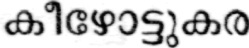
കീഴോട്ടുകര
